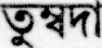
তুম্বদা
